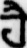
ਹੈ
